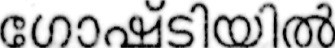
ഗോഷ്ടിയില്‍
